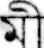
মী
